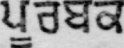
ਪੂਰਬਕ
